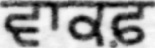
ਵਾਕਫ਼
